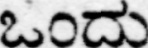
ಒಂದು
